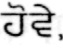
ਹੋਵੇ,
